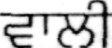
ਵਾਲੀ
